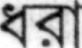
ধরা
